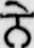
ਨੇ
